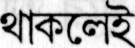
থাকলেই
